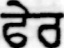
ਫੇਰ
